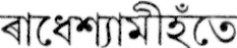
ৰাধেশ্যামীহঁতে
